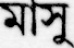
মাসু
